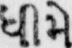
ધીમે
